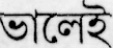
ভালেই
